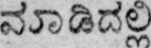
ಮಾಡಿದಲ್ಲಿ
